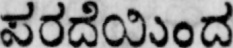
ಪರದೆಯಿಂದ
